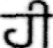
ਹੀ
